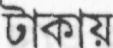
টাকায়
